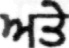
ਅਤੇ
